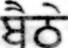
ਬੈਠੇ
